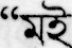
"মই
